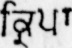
ਕ੍ਰਿਪਾ
